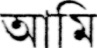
আমি
